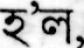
হ'ল,
